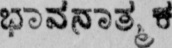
ಭಾವನಾತ್ಮಕ
